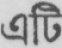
এটি
